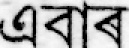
এবাৰ
